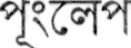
পূংলেপ
